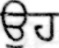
ਉਹ
